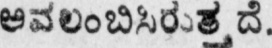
ಅವಲಂಬಿಸಿರುತ್ತದೆ.
